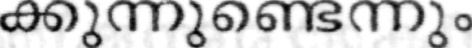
ക്കുന്നുണ്ടെന്നും
